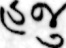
હજુ
